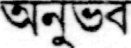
অনুভব
